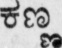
ಕಣ್ಣ
